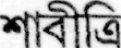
শাবীত্রি
